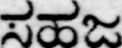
ಸಹಜ
